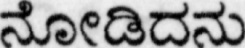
ನೋಡಿದನು
